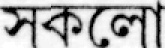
সকলো
